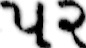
પર
